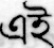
এই
